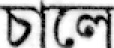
চালে
